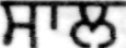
ਸਾਲ
